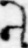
ને
